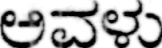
ಅವಳು
